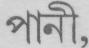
পানী,
